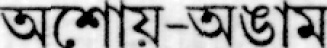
অশোয়-অঙাম
